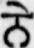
ਨੇ
